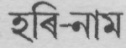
হৰি-নাম
